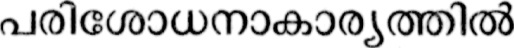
പരിശോധനാകാര്യത്തില്‍
